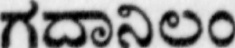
ಗದಾನಿಲಂ
